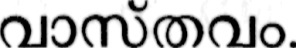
വാസ്തവം.
